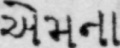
એમના
